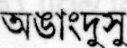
অঙাংদুসু
